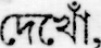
দেখোঁ,
